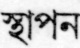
স্থাপন
